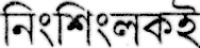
নিংশিংলকই
